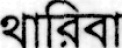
থারিবা
